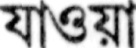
যাওয়া
